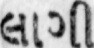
લાગી
